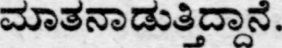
ಮಾತನಾಡುತ್ತಿದ್ದಾನೆ.
